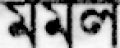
মমল
